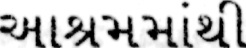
આશ્રમમાંથી
